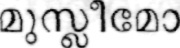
മുസ്ളീമോ
